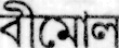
বীমোল
